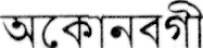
অকোনবগী
